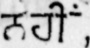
ਨਹੀਂ,
